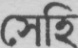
সেহি
